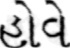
હોવે
